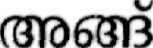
അങ്ങ്
